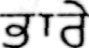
ਭਾਰੇ
